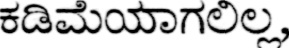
ಕಡಿಮೆಯಾಗಲಿಲ್ಲ,
